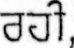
ਰਹੀ,
